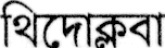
থিদোক্লবা
